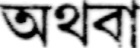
অথবা
